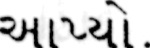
આપ્યો.
